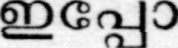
ഇപ്പോ
